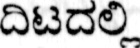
ದಿಟದಲ್ಲಿ
